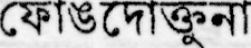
ফোঙদোক্তুনা
